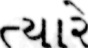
ત્યારે
